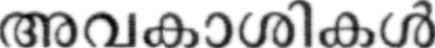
അവകാശികള്‍
